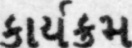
કાર્યક્રમ
